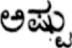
ಅಷ್ಟು
